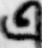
এ
